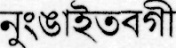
নুংঙাইতবগী
